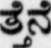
ತ್ತೆನೆ
